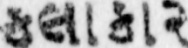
કલાકાર
